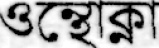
ওন্থোক্না
